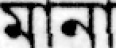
মানা
